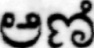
ಅಣಿ
